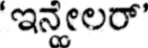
'ಇನ್ಹೇಲರ್'
